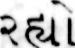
રહ્યો
